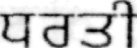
ਧਰਤੀ
